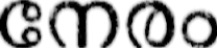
നേരം
